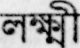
লক্ষ্মী
